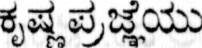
ಕೃಷ್ಣಪ್ರಜ್ಞೆಯು
